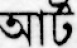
আর্ট
